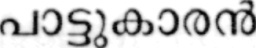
പാട്ടുകാരന്‍
